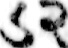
ડર
